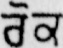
ਰੋਕ
